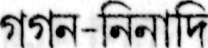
গগন-নিনাদি
